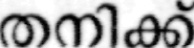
തനിക്ക്
